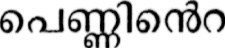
പെണ്ണിന്റെ
